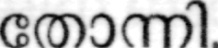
തോന്നി.
